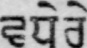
ਵਧੇਰੇ
